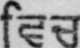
ਵਿਚ
